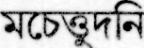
মচেত্তুদনি
